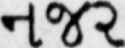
નજર
